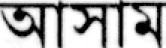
আসাম
